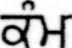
ਕੰਮ
